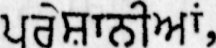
ਪਰੇਸ਼ਾਨੀਆਂ,
